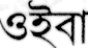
ওইবা
